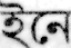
ইনে
